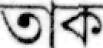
তাক
